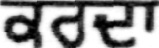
ਕਰਦਾ
